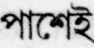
পাশেই
